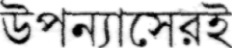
উপন্যাসেরই
